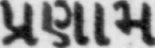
પ્રણામ
